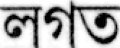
লগত
